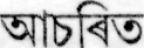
আচৰিত
